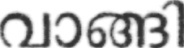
വാങ്ങി
